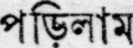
পড়িলাম
